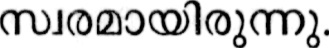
സ്വരമായിരുന്നു.
